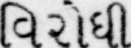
વિરોધી
